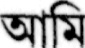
আমি
